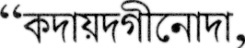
“কদায়দগীনোদা,
